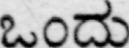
ಒಂದು
